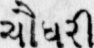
ચૌધરી
